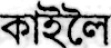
কাইলৈ
